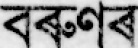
বৰুণৰ
